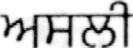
ਅਸਲੀ
